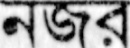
নজর
